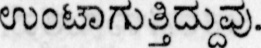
ಉಂಟಾಗುತ್ತಿದ್ದುವು.
